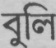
বুলি
